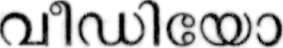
വീഡിയോ
